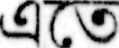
এতে
